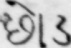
છોડ
